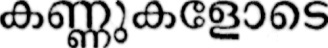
കണ്ണുകളോടെ
